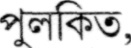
পুলকিত,
